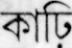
কাঢ়ি
